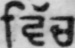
ਵਿੱਚ
